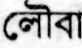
লৌবা
